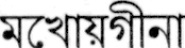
মখোয়গীনা
